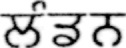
ਲੰਡਨ
